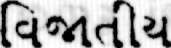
વિજાતીય
